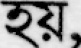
হয়,
